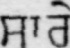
ਸਾਰੇ
